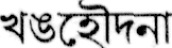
খঙহৌদনা
